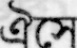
ঐসে
